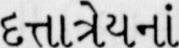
દત્તાત્રેયનાં
